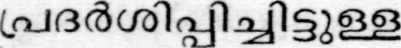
പ്രദര്‍ശിപ്പിച്ചിട്ടുള്ള
